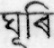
ঘূৰি
